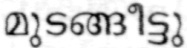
മുടങ്ങീട്ടു
